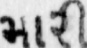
મારી
